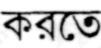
করতে
